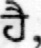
ਹੈ,
